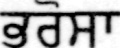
ਭਰੋਸਾ
